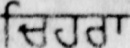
ਚਿਹਰਾ
